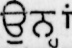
ਉਨ੍ਹਾਂ
